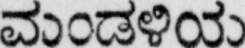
ಮಂಡಳಿಯ
